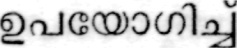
ഉപയോഗിച്ച്
